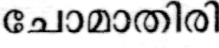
ചോമാതിരി
